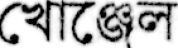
খোঞ্জেল
